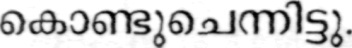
കൊണ്ടുചെന്നിട്ടു.
